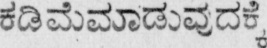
ಕಡಿಮೆಮಾಡುವುದಕ್ಕೆ
